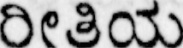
ರೀತಿಯ
